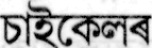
চাহকেলৰ
